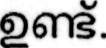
ഉണ്ട്.
